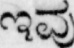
ಇವು
